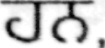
ਹਨ,
